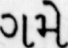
ગમે
